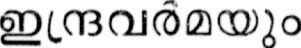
ഇന്ദ്രവര്‍മയും
